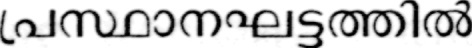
പ്രസ്ഥാനഘട്ടത്തില്‍
